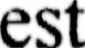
est
